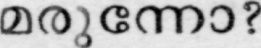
മരുന്നോ?
